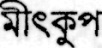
মীৎকুপ
